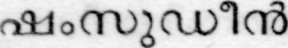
ഷംസുഡീന്‍
